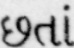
છતાં
